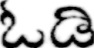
ಓಡಿ
